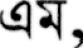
এম,
